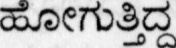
ಹೋಗುತ್ತಿದ್ದ
